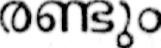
രണ്ടും
